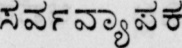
ಸರ್ವವ್ಯಾಪಕ
